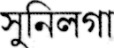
সুনিলগা
